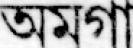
অমগা
